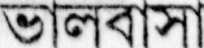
ভালবাসা
